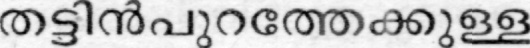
തട്ടിന്‍പുറത്തേക്കുള്ള
